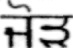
ਜੋੜ
